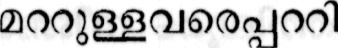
മററുള്ളവരെപ്പററി
